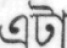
এটা
